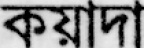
কয়াদা
